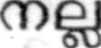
നല്ല
